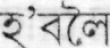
হ'বলৈ
